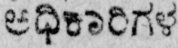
ಅಧಿಕಾರಿಗಳ
